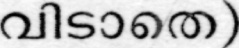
വിടാതെ)
